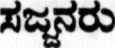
ಸಜ್ಜನರು
